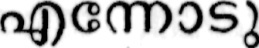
എന്നോടു
